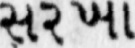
સરખા
